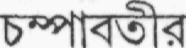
চম্পাবতীর
